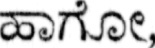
ಹಾಗೋ,
